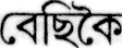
বেছিকৈ
